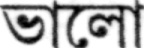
ভালো
